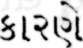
કારણે
